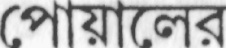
পোয়ালের
